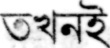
তখনই
